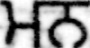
ਮਨ
